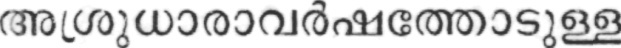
അശ്രുധാരാവര്‍ഷത്തോടുള്ള
